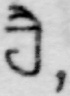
ਹੈ,
